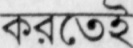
করতেই
